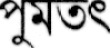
পুমতৎ
